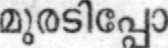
മുരടിപ്പോ
